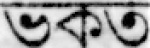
ভকত
